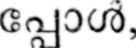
പ്പോള്‍,
